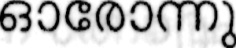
ഓരോന്നു
